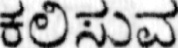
ಕಲಿಸುವ
